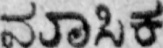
ಮಾಸಿಕ
